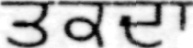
ਤਕਦਾ
